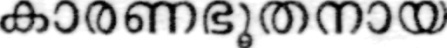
കാരണഭൂതനായ
